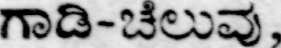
ಗಾಡಿ-ಚೆಲುವು,
